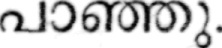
പാഞ്ഞു.
